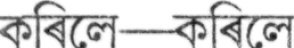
কৰিলে-কৰিলে
